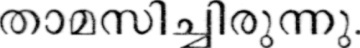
താമസിച്ചിരുന്നു.
